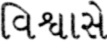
વિશ્વાસે
